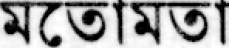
মতোমতা
